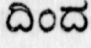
ದಿಂದ
